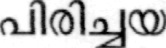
പിരിച്ചയ
